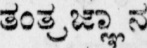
ತಂತ್ರಜ್ಞಾನ
